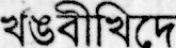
খঙবীখিদে
